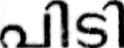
പിടി
